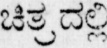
ಚಿತ್ರದಲ್ಲಿ
